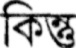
কিন্তু
